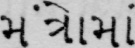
મંત્રોમાં
